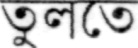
তুলতে
